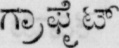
ಗ್ರಾಫೈಟ್
